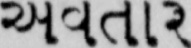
અવતાર
